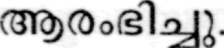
ആരംഭിച്ചു.
